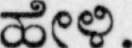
ಹೇಳಿ.
